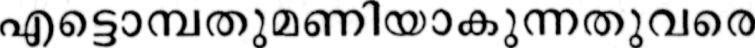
എട്ടൊമ്പതുമണിയാകുന്നതുവരെ
